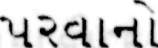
પરવાનો
